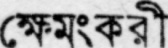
ক্ষেমংকরী
